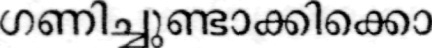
ഗണിച്ചുണ്ടാക്കിക്കൊ
